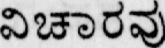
ವಿಚಾರವು
